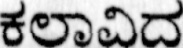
ಕಲಾವಿದ
